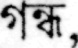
গন্ধ,
